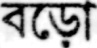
বড়ো
